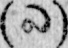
(ಎ)
